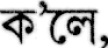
ক'লে,
